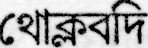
থোক্লবদি
